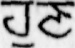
ਹੁਣ
